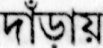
দাঁড়ায়
